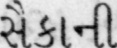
સૈકાની
